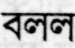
বলল
